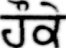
ਹੌਕੇ
